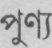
পুণ্য
